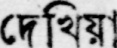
দেখিয়া
